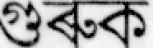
গুৰুক
